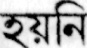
হয়নি
